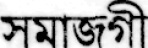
সমাজগী
